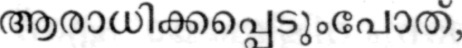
ആരാധിക്കപ്പെടുംപോത്,
